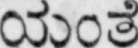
ಯಂತೆ
